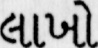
લાખો
